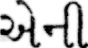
એની
